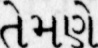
તેમણે
